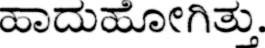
ಹಾದುಹೋಗಿತ್ತು.
